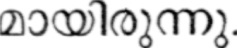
മായിരുന്നു.
